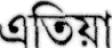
এতিয়া
